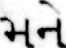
મને
